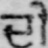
ਦੀ
